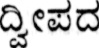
ದ್ವೀಪದ
